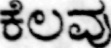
ಕೆಲವು
